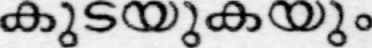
കുടയുകയും
